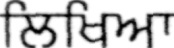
ਲਿਖਿਆ
